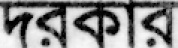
দরকার
